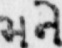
મને
